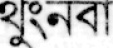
থুংনবা
